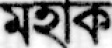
মহাক
